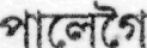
পালেগৈ
